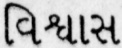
વિશ્વાસ
